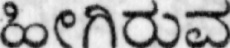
ಹೀಗಿರುವ
